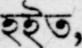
হইত,
